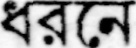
ধরনে
